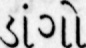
ડાંગો
